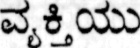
ವ್ಯಕ್ತಿಯು
